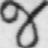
જ
